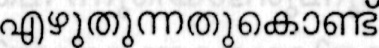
എഴുതുന്നതുകൊണ്ട്
